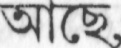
আছে,
